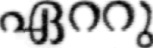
ഏററു
